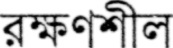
রক্ষণশীল
